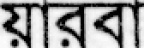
য়ারবা
